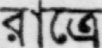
রাত্রে
